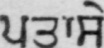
ਪਤਾਸੇ
